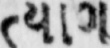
ત્યાગ
